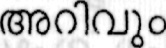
അറിവും
